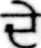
ਦੇ
